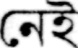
নেই
